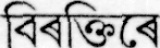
বিৰক্তিৰে
